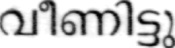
വീണിട്ടു
